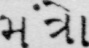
મંત્રો
